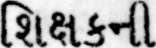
શિક્ષકની
